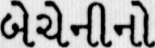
બેચેનીનો
